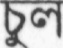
চুল
